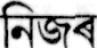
নিজৰ
